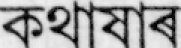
কথাষাৰ
